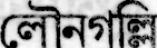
লৌনগল্লি
